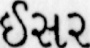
ઈસર
